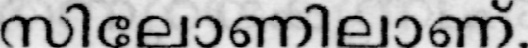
സിലോണിലാണ്.
